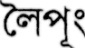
লৈপূং
